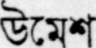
উমেশ
